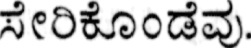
ಸೇರಿಕೊಂಡೆವು.
